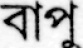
বাপু
